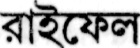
রাইফেল
